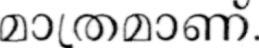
മാത്രമാണ്.
